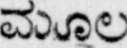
ಮೂಲ
